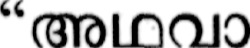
“അഥവാ
